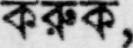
করুক,
